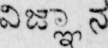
ವಿಜ್ಞಾನ
